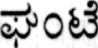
ಘಂಟೆ
